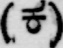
(ಕ)
